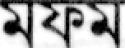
মফম
